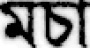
মচা
